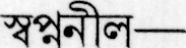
স্বপ্ননীল-
